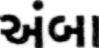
અંબા
